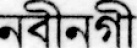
নবীনগী
